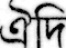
ঐদি
